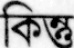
কিন্তু
